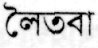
লৈতবা
